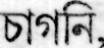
চাগনি,
